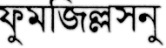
ফুমজিল্লসনু
